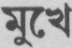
মুখে
